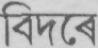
বিদৰে
